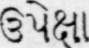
ઉપેક્ષા
